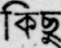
কিছু
